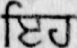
ਇਹ
